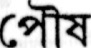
পৌষ
